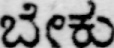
ಬೇಕು
